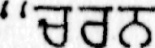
''ਚਰਨ
